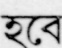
হবে
